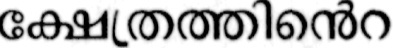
ക്ഷേത്രത്തിന്റെ
